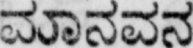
ಮಾನವನ
